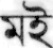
মই
